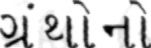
ગ્રંથોનો
